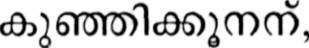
കുഞ്ഞിക്കൂനന്,
